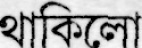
থাকিলো
